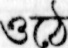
ওঠে
